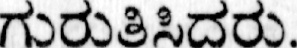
ಗುರುತಿಸಿದರು.
